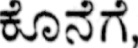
ಕೊನೆಗೆ,
